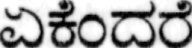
ಏಕೆಂದರೆ
